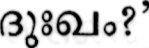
ദുഃഖം?'
